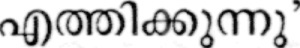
എത്തിക്കുന്നു.'
